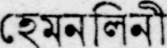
হেমনলিনী
